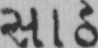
સાઠ
